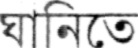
ঘানিতে
